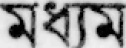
মধ্যম
